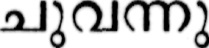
ചുവന്നു
